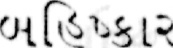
બહિષ્કાર
